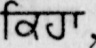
ਕਿਹਾ,
